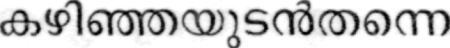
കഴിഞ്ഞയുടന്‍തന്നെ
